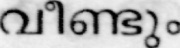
വീണ്ടും
